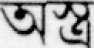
অস্ত্র
